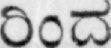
ರಿಂದ
